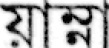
য়াম্না
